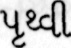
પૃથ્વી
